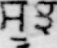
ਸੂਝ
